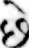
છે
